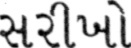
સરીખો
